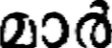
മാര്‍
